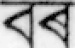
বৰ
